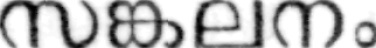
സങ്കലനം
